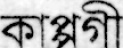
কাপ্পগী
